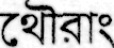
থৌরাং
